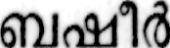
ബഷീര്‍
